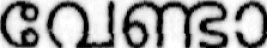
വേണ്ടാ
